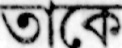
তাকে
